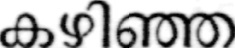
കഴിഞ്ഞ
